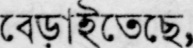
বেড়াইতেছে,
